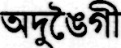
অদুঙৈগী
